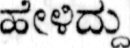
ಹೇಳಿದ್ದು
